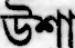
উশা
